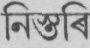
নিস্তৰি
